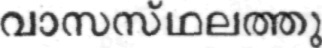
വാസസ്ഥലത്തു
